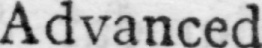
Advanced
